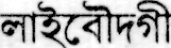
লাইবৌদগী
